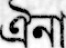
ঐনা
